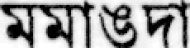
মমাঙদা
